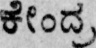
ಕೇಂದ್ರ
